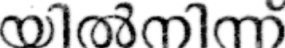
യില്‍നിന്ന്
